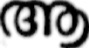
ആ
